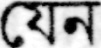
যেন
